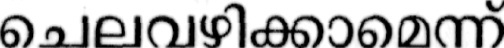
ചെലവഴിക്കാമെന്ന്
